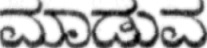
ಮಾಡುವ
